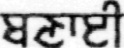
ਬਣਾਈ
